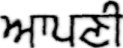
ਆਪਣੀ
